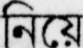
নিয়ে
